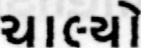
ચાલ્યો
